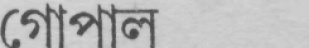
গোপাল
